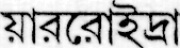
য়াররোইদ্রা
